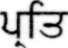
ਪ੍ਰਤਿ
